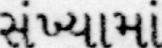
સંખ્યામાં
